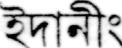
ইদানীং
